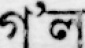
গ'ল
